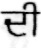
ਦੀ
